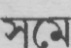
সমে
